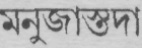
মনুজাস্তদা
